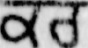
ਕਰ
